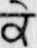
ਕੇ
